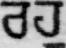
ਰਹੁ
